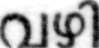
വഴി
